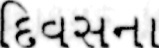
દિવસના
